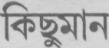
কিছুমান
